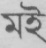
মই
